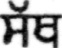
ਸੱਥ
